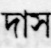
দাস
